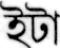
ইটা
